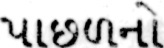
પાછળનો
